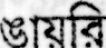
ঙায়রি
